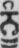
ਨੂੰ
